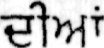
ਦੀਆਂ
